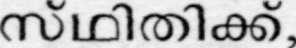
സ്ഥിതിക്ക്,
